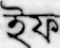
ইফ
